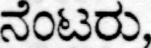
ನೆಂಟರು,
